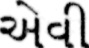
એવી
